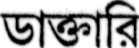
ডাক্তারি
